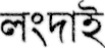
লংদাই
